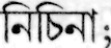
নিচিনা;
